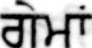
ਗੇਮਾਂ
